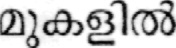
മുകളില്‍
